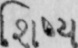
શિષ્ય
